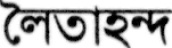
লৈতাহন্দ
